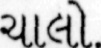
ચાલો.
